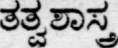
ತತ್ವಶಾಸ್ತ್ರ
